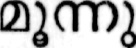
മൂന്നു
